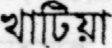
খাটিয়া
